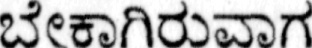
ಬೇಕಾಗಿರುವಾಗ
